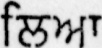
ਲਿਆ
